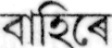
বাহিৰে
